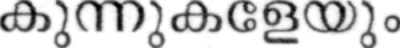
കുന്നുകളേയും
